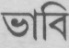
ভাবি
